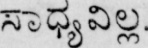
ಸಾಧ್ಯವಿಲ್ಲ.
